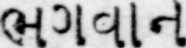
ભગવાન
